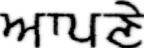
ਆਪਣੇ
